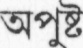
অপুষ্ট
